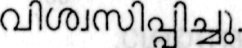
വിശ്വസിപ്പിച്ചു.
